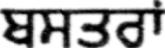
ਬਸਤਰਾਂ
